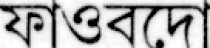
ফাওবদো
